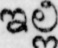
ಇಲ್ಲಿ
